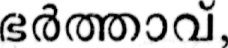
ഭര്‍ത്താവ്,
